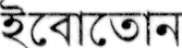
ইবোতোন
